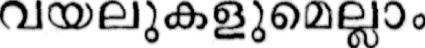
വയലുകളുമെല്ലാം
